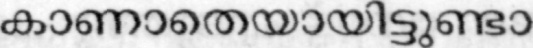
കാണാതെയായിട്ടുണ്ടാ
